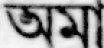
অমা
